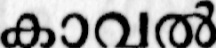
കാവല്‍
